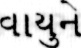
વાયુને
